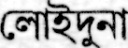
লোইদুনা
